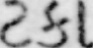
ટકા
